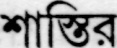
শাস্তির
